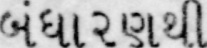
બંધારણથી
